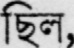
ছিল,
